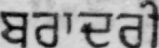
ਬਰਾਦਰੀ
